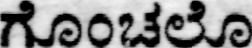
ಗೊಂಚಲೊ
